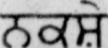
ਨਕਸ਼ੇ
